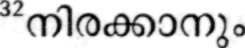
32നിരക്കാനും
